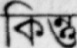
কিন্তু
